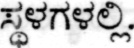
ಸ್ಥಳಗಳಲ್ಲಿ.
